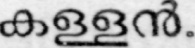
കള്ളന്‍.
